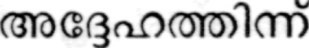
അദ്ദേഹത്തിന്ന്
